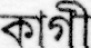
কাগী
